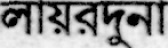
লায়রদুনা
